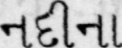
નદીના
